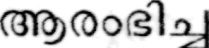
ആരംഭിച്ച
